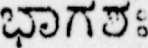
ಭಾಗಶಃ
